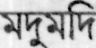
মদুমদি
